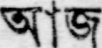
আজ
